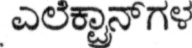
ಎಲೆಕ್ಟ್ರಾನ್ ಗಳ
